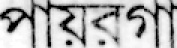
পায়রগা
